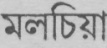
মলচিয়া
